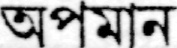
অপমান
